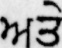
ਅਤੇ
